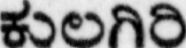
ಕುಲಗಿರಿ
